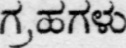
ಗ್ರಹಗಳು
